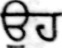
ਉਹ
